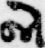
જો
